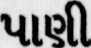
પાણી
